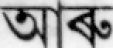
আৰু
